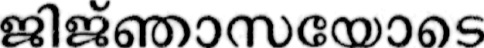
ജിജ്ഞാസയോടെ
